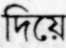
দিয়ে
